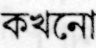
কখনো
